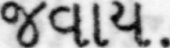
જવાય.
